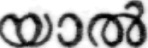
യാല്‍
